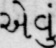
એવું
